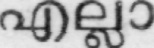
എല്ലാ
